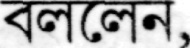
বললেন,
